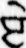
ਏ
